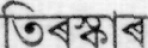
তিৰস্কাৰ
